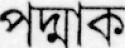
পদ্মাক
